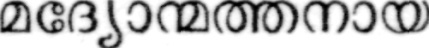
മദ്യോന്മത്തനായ
